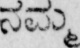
ನಮ್ಮ
